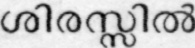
ശിരസ്സില്‍
